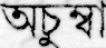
অচুম্বা
